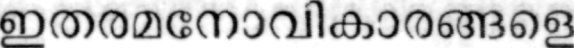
ഇതരമനോവികാരങ്ങളെ
